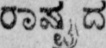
ರಾಷ್ಟ್ರದ
